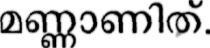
മണ്ണാണിത്.
